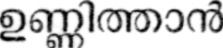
ഉണ്ണിത്താന്‍
